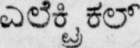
ಎಲೆಕ್ಟ್ರಿಕಲ್
